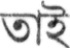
তাই
